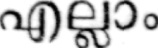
എല്ലാം
